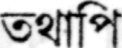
তথাপি
